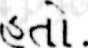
હતો.
